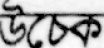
উচেক
